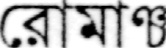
রোমাঞ্চ
